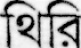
থিরি
